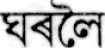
ঘৰলৈ
